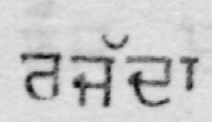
ਰਜੱਦਾ
